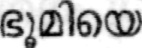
ഭൂമിയെ
